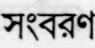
সংবরণ
